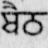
ਬੈਠ
